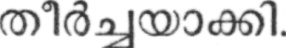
തീര്‍ച്ചയാക്കി.
